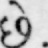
છે.
